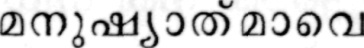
മനുഷ്യാത്മാവെ
